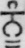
ਨੂੰ
